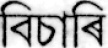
বিচাৰি
